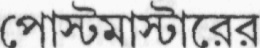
পোস্টমাস্টারের
